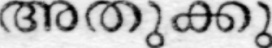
അതുക്കു
